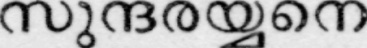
സുന്ദരയ്യനെ
